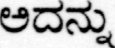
ಅದನ್ನು
